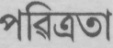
পৱিত্রতা
